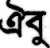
ঐবু
